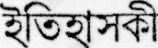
ইতিহাসকী
